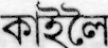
কাইলৈ
